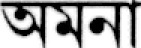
অমনা
